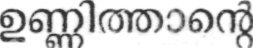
ഉണ്ണിത്താന്റെ
